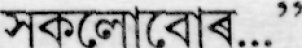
সকলোবোৰ..."
